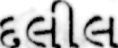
દલીલ
